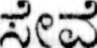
ಸೇವೆ
